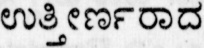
ಉತ್ತೀರ್ಣರಾದ
